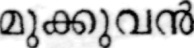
മുക്കുവന്‍
